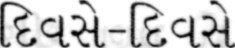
દિવસે-દિવસે
